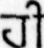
ਹੀ
